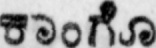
ಕಾಂಗೊ
